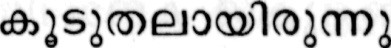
കൂടുതലായിരുന്നു
